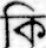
কি
